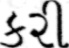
કરી
